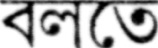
বলতে
